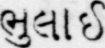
ભુલાઈ
